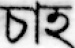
চাহ
